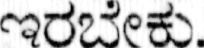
ಇರಬೇಕು.
